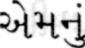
એમનું
